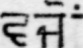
ਵਜੋਂ
